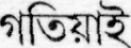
গতিয়াই
